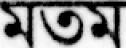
মতম
